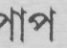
পাপ
